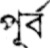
পূর্ব
